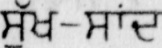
ਸੁੱਖ-ਸਾਂਦ
